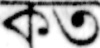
কত
